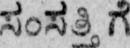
ಸಂಸತ್ತಿಗೆ
